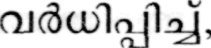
വര്‍ധിപ്പിച്ച്,
